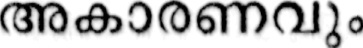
അകാരണവും
